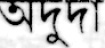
অদুদা
